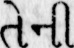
તેની
